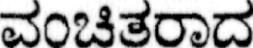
ವಂಚಿತರಾದ
